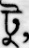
টু,
